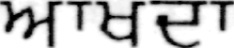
ਆਖਦਾ
